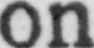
on
